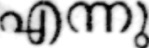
എന്നു
